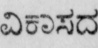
ವಿಕಾಸದ
